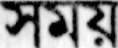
সময়
